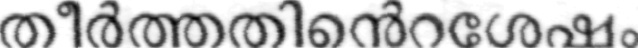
തീര്‍ത്തതിന്റെശേഷം
